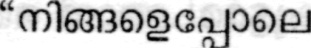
“നിങ്ങളെപ്പോലെ
